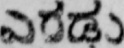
ಎರಡು
